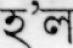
হ'ল
